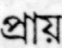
প্রায়
